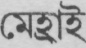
মেহ্রাই
